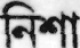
নিশা
